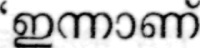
‘ഇന്നാണ്
